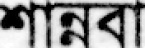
শান্নবা
